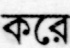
করে
